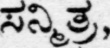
ಸನ್ಮಿತ್ರ,
